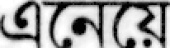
এনেয়ে
